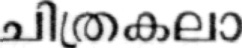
ചിത്രകലാ
